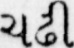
ચઢી
